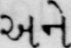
અને
